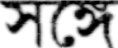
সঙ্গে
